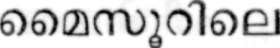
മൈസൂറിലെ
